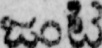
ಜಂಟಿ
